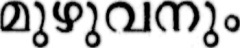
മുഴുവനും
